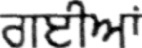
ਗਈਆਂ
